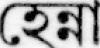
হেন্না
